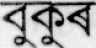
বুকুৰ
